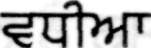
ਵਧੀਆ
